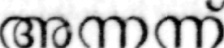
അന്നന്ന്
